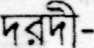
দরদী-
